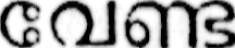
വേണ്ട
